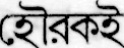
হৌরকই
